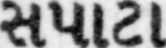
સપાટા
